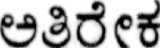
ಅತಿರೇಕ
